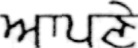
ਆਪਣੇ
